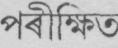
পৰীক্ষিত
